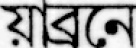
য়াব্রনে
